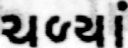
ચળ્યાં
